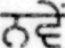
ਨਵੇਂ
